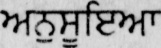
ਅਨੁਸੂਇਆ
